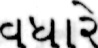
વધારે
